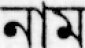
নাম
